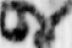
જ
